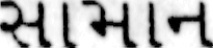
સામાન
